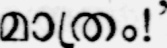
മാത്രം!'
